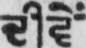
ਦੀਵੇਂ
